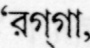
‘রগ্গা,
